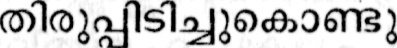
തിരുപ്പിടിച്ചുകൊണ്ടു
